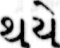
થયે
